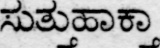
ಸುತ್ತುಹಾಕ್ತಾ
